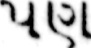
પણ
